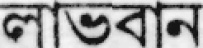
লাভবান
